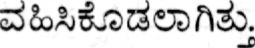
ವಹಿಸಿಕೊಡಲಾಗಿತ್ತು.
